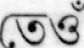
তেওঁ
